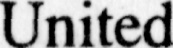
United
